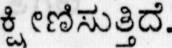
ಕ್ಷೀಣಿಸುತ್ತಿದೆ.
